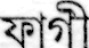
ফাগী
